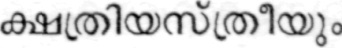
ക്ഷത്രിയസ്ത്രീയും
